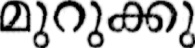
മുറുക്കു
